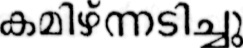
കമിഴ്ന്നടിച്ചു
